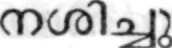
നശിച്ചു
